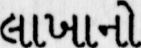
લાખાનો
